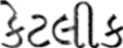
કેટલીક
